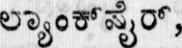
ಲ್ಯಾಂಕ್ಷೈರ್,
